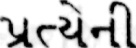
પ્રત્યેની
